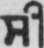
ਸੀ
